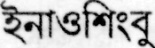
ইনাওশিংবু
